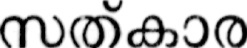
സത്കാര
